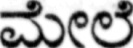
ಮೇಲೆ
